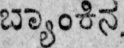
ಬ್ಯಾಂಕಿನ
